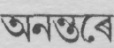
অনন্তৰে
